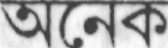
অনেক
